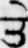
ਤੇ
